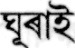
ঘূৰাই
